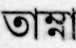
তাম্না
